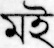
মই
